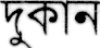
দুকান
